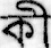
কী
